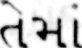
તેમાં
